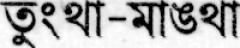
তুংথা-মাংথা
